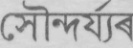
সৌন্দৰ্য্যৰ
